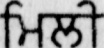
ਮਿਲੀ
